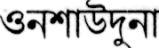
ওনশাউদুনা
